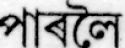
পাৰলৈ
